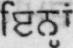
ਇਨ੍ਹਾਂ
